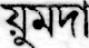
য়ুমদা
